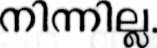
നിന്നില്ല.
